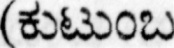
(ಕುಟುಂಬ
